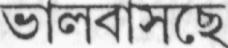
ভালবাসছে
